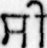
ਸੀ
